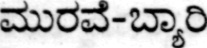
ಮುರವೆ-ಬ್ಯಾರಿ
